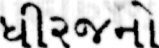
ધીરજનો
